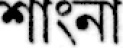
শাংনা
